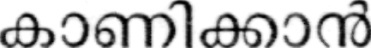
കാണിക്കാന്‍
